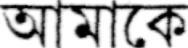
আমাকে
